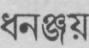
ধনঞ্জয়
